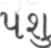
પશુ
